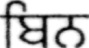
ਬਿਨ
